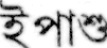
ইপাশু
